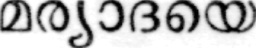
മര്യാദയെ
